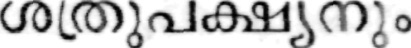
ശത്രുപക്ഷ്യനും
